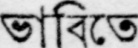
ভাবিতে
